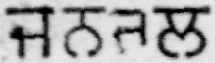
ਜਨਰਲ
